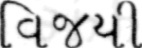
વિજયી
